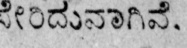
ಸೇರಿದುವಾಗಿದೆ.
